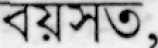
বয়সত,
